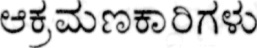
ಆಕ್ರಮಣಕಾರಿಗಳು
